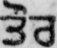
ਤੌਰ
